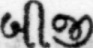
બીજી
